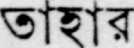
তাহার
